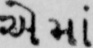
એમાં
